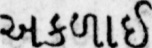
અકળાઈ
